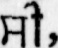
ਸੀ,
